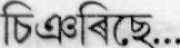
চিঞৰিছে...
